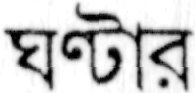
ঘন্টার
